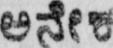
ಅನೇಕ
